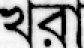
খরা
